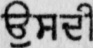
ਉਸਦੀ
